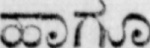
ಹಾಗೂ
